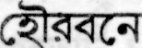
হৌরবনে
